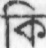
কি
